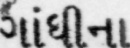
ગાંધીના
